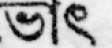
ভোৎ
